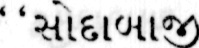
"સોદાબાજી
